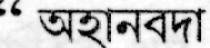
“অহানবদা
